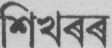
শিখৰৰ
